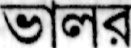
ভালর
